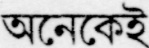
অনেকেই
